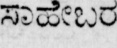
ಸಾಹೇಬರ
